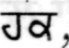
ਹਕ,
